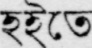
হইতে
